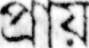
প্রায়
